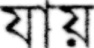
যায়
